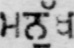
ਮਨੁੱਖ
